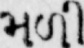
મળી
